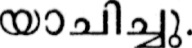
യാചിച്ചു.
